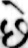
છે
